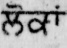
ਲੋਕਾਂ
